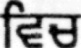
ਵਿਚ
